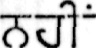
ਨਹੀਂ
